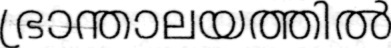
ഭ്രാന്താലയത്തില്‍
